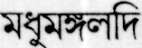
মধুমঙ্গলদি
